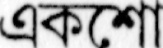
একশো
